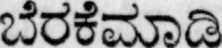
ಬೆರಕೆಮಾಡಿ
